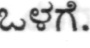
ಒಳಗೆ.
